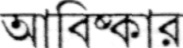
আবিষ্কার
